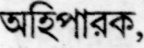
অহিপারক,
